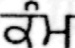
ਕੰਮ
